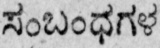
ಸಂಬಂಧಗಳ
